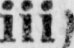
iii)
